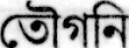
তৌগনি
